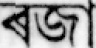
ৰজা
